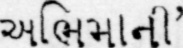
અભિમાની'
